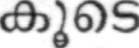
കൂടെ
